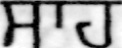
ਸਾਹ
